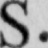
S.
